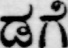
ಡಗೆ
